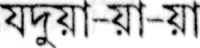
যদুয়া-য়া-য়া
